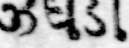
ઝઘડા
